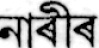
নাৰীৰ
